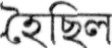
হৈছিল
